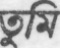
তুমি
